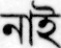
নাই
